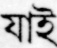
যাই
